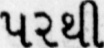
પરથી
